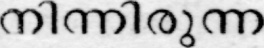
നിന്നിരുന്ന
